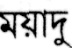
ময়াদু
